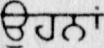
ਉਹਨਾਂ
